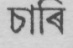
চাৰি
